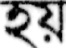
হয়
